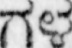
ಗಳ
